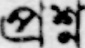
প্রশ্ন
